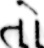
તો
